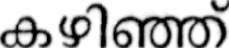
കഴിഞ്ഞ്
